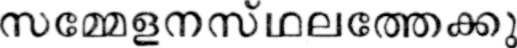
സമ്മേളനസ്ഥലത്തേക്കു
